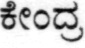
ಕೇಂದ್ರ
